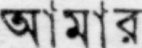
আমার
